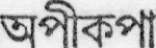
অপীকপা
